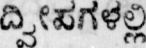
ದ್ವೀಪಗಳಲ್ಲಿ
